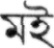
মই
